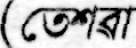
(তেশৱা
